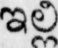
ಇಲ್ಲಿ
